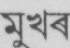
মুখৰ
